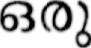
ഒരു
